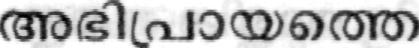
അഭിപ്രായത്തെ
